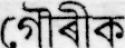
গৌৰীক
